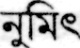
নুমিৎ
